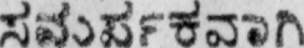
ಸಮರ್ಪಕವಾಗಿ
